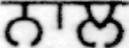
ਨਾਲ
